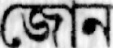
জোন
